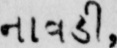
નાવડી,
